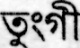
তুংগী
